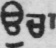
ਉਚਾ
